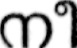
നീ
